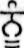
ਨੂੰ
